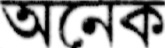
অনেক
